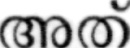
അത്
